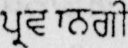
ਪ੍ਰਵਾਨਗੀ
